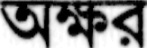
অক্ষর
